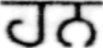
ਹਨ
